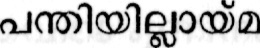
പന്തിയില്ലായ്മ
